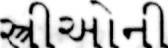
સ્ત્રીઓની
